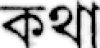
কথা
